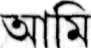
আমি
